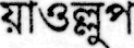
য়াওল্লুপ
